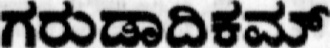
ಗರುಡಾದಿಕಮ್
